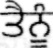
ਤੈਨੂੰ
